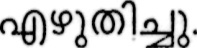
എഴുതിച്ചു.
